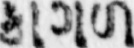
કાગળ
